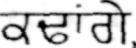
ਕਢਾਂਗੇ,
